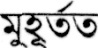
মুহূর্তত
